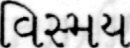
વિસ્મય
